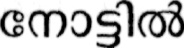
നോട്ടില്‍
